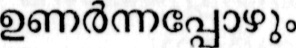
ഉണര്‍ന്നപ്പോഴും
